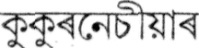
কুকুৰনেচীয়াৰ
